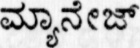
ಮ್ಯಾನೇಜ್
